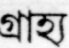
গ্রাহ্য
